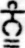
ਨੂੰ
